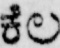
ಕೆಲ
